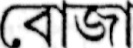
বোজা
